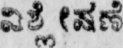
ವಿಶ್ಲೇಷಣೆ
